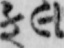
ફલ
